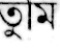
তুমি
